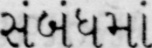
સંબંધમાં
